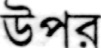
উপর
